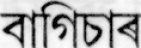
বাগিচাৰ
